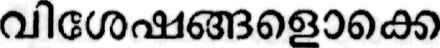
വിശേഷങ്ങളൊക്കെ
